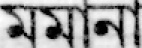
মমানা
